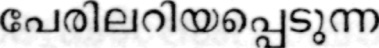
പേരിലറിയപ്പെടുന്ന
